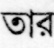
তার
